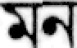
মন
